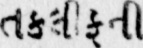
તકલીફની
